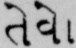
તેવો
